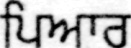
ਪਿਆਰ
